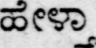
ಹೇಳ್ತಾ
